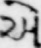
એ
